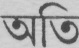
অতি
